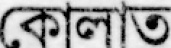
কোলাত
